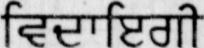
ਵਿਦਾਇਗੀ
